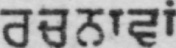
ਰਚਨਾਵਾਂ
